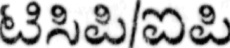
ಟಿಸಿಪಿ/ಐಪಿ
